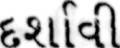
દર્શાવી
